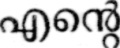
എന്റെ
